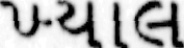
ખ્યાલ
